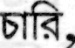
চারি,
